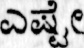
ಎಷ್ಟೇ
